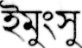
ইমুংসু
